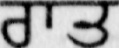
ਰਾਤ
